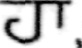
ਹਾਂ,
